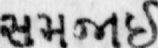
સમજાઈ
